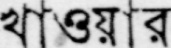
খাওয়ার
